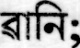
ৱানি;
